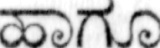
ಹಾಗೂ
